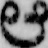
ಆ
